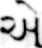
એ
